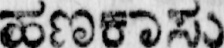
ಹಣಕಾಸು
